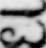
ವ
